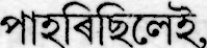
পাহৰিছিলেই,
